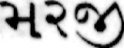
મરજી
